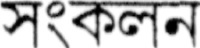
সংকলন
